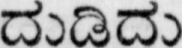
ದುಡಿದು
